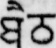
ਬੈਠ
